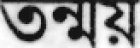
তন্ময়
